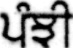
ਪੰਝੀ
